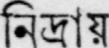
নিদ্রায়
